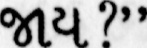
જાય?"
